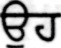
ਉਹ
